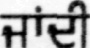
ਜਾਂਦੀ
